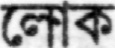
লোক
